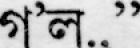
গ'ল.."
